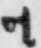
ન
